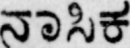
ನಾಸಿಕ
